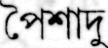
পৈশাদু
